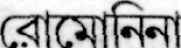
রোমোনিনা
